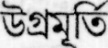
উগ্রমূর্তি
